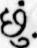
છું.
